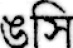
ঙসি
